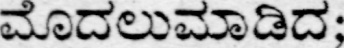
ಮೊದಲುಮಾಡಿದ;
